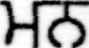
ਮਨ
